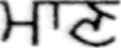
ਮਾਣ
